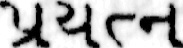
પ્રયત્ન
